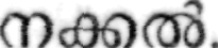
നക്കല്‍.
